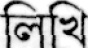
লিখি
